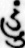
હું
